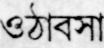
ওঠাবসা
